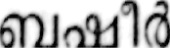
ബഷീര്‍
